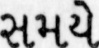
સમયે
